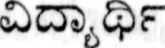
ವಿದ್ಯಾರ್ಥಿ
